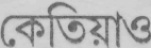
কেতিয়াও
